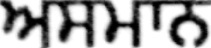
ਅਸਮਾਨ
